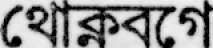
থোক্নবগে
